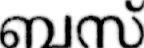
ബസ്
